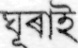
ঘূৰাই
